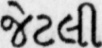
જેટલી
